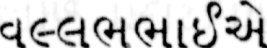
વલ્લભભાઈએ
